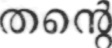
തന്റെ
